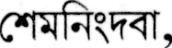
শেমনিংদবা,
